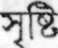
সৃষ্টি
